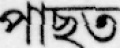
পাছত
